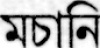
মচানি
